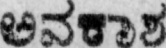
ಅವಕಾಶ
